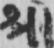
શ્રી
